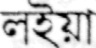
লইয়া
